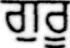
ਗੁਰੂ
